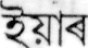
ইয়াৰ
